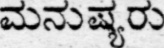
ಮನುಷ್ಯರು
